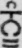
ਨੂੰ
